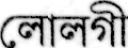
লোলগী
